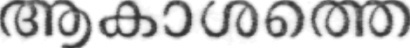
ആകാശത്തെ
